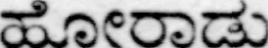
ಹೋರಾಡು
